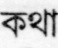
কথা
